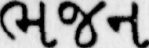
ભજન
